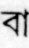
বা
